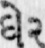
ઘેર
